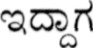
ಇದ್ದಾಗ
